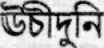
ঊচীদুনি
